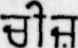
ਚੀਜ਼
